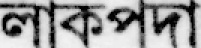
লাকপদা
